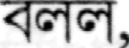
বলল,
